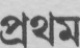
প্ৰথম
